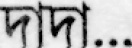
দাদা...
